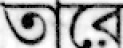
তারে
